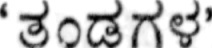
'ತಂಡಗಳ'
